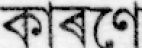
কাৰণে
